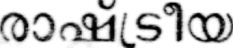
രാഷ്ട്രീയ
